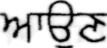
ਆਉਣ
